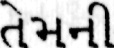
તેમની
